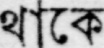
থাকে
